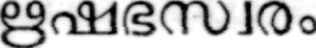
ഋഷഭസ്വരം
